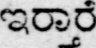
ಇರ್‍ತಾರೆ
